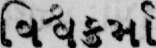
વિશ્વકર્મા
